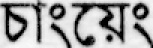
চাংয়েং
